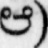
ಆ)
